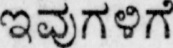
ಇವುಗಳಿಗೆ
